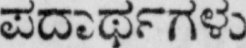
ಪದಾರ್ಥಗಳು
